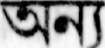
অন্য
